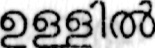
ഉള്ളില്‍
